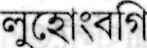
লুহোংবগি
